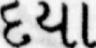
દયા
